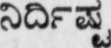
ನಿರ್ದಿಷ್ಟ
